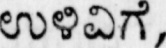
ಉಳಿವಿಗೆ,
